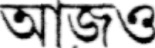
আজও
